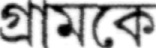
গ্রামকে
